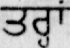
ਤਰ੍ਹਾਂ
